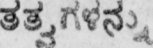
ತತ್ವಗಳನ್ನು
